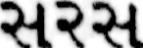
સરસ
